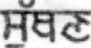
ਸੁੱਥਣ
